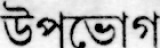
উপভোগ
